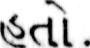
હતો.
